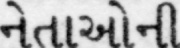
નેતાઓની
